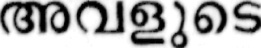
അവളുടെ
